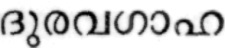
ദുരവഗാഹ
